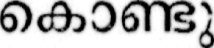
കൊണ്ടു
